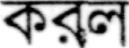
করল
